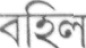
বহিল
